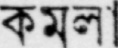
কমলা
